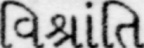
વિશ્રાંતિ
